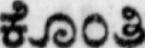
ಕೊಂತಿ
